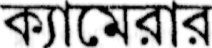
ক্যামেরার
